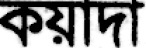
কয়াদা
